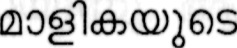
മാളികയുടെ
